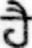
ਹੈ
